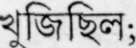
খুজিছিল;
